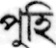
পুহি
